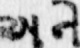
અને
